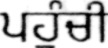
ਪਹੁੰਚੀ
